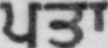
ਪਤਾ
